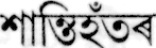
শান্তিহঁতৰ
